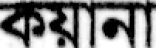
কয়ানা
